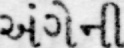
અંગેની
